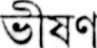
ভীষণ
